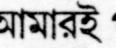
আমারই
